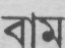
বাম
